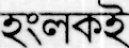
হংলকই
